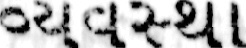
વ્યવસ્થા
